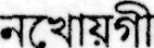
নখোয়গী
